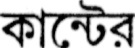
কান্টের
